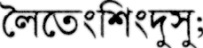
লৈতেংশিংদুসু;
